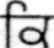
ਕਿ
